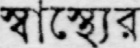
স্বাস্থ্যের
